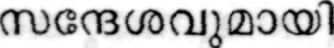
സന്ദേശവുമായി
